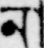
না
